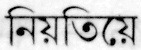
নিয়তিয়ে
